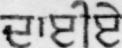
ਦਾਈਏ
